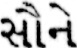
સૌને
